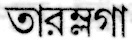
তারম্লগা
